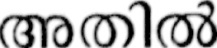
അതില്‍
